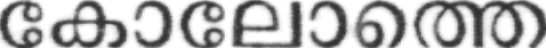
കോലോത്തെ
